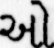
ઓ
